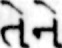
તેને
